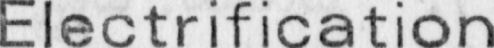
Electrification
